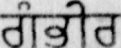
ਗੰਭੀਰ
